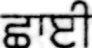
ਛਾਈ
